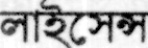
লাইসেন্স
